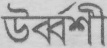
উৰ্ব্বশী
